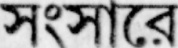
সংসারে
